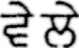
ਵੇਲੇ
